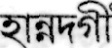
হান্নদগী
